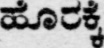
ಹೊರಕ್ಕೆ
